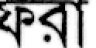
ফরা
